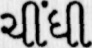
ચીંધી
